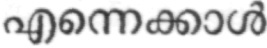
എന്നെക്കാള്‍
